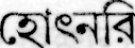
হোৎনরি
